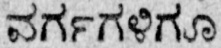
ವರ್ಗಗಳಿಗೂ
